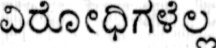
ವಿರೋಧಿಗಳೆಲ್ಲ
